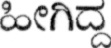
ಹೀಗಿದ್ದ
